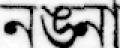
নঙনা
